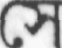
সে
